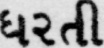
ધરતી
